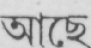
আছে
